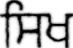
ਸਿਖ
